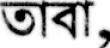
তাবা,
